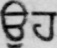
ਉਹ
